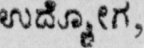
ಉದ್ಯೋಗ,
